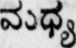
ಮಧ್ಯ
